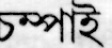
চম্পাই
